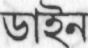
ডাইন
